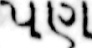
પણ
